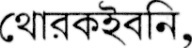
থোরকইবনি,
